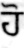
ਹੋ
